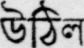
উঠিল
